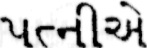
પત્નીએ
